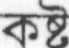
কষ্ট
